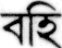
বহি
